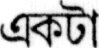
একটা
